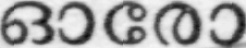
ഓരോ
